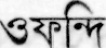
ওফন্দি
